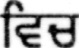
ਵਿਚ
